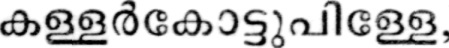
കള്ളര്‍കോട്ടുപിള്ളേ,
